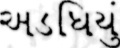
અડધિયું
